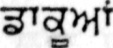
ਡਾਕੂਆਂ
